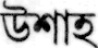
উশাহ
